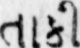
તાકી
